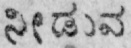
ನೀಡುವ
